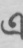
এ
